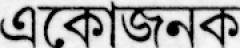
একোজনক
